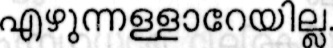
എഴുന്നള്ളാറേയില്ല.
